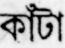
কাঁটা
